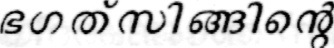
ഭഗത്സിങ്ങിന്റെ
